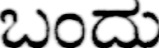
ಬಂದು
